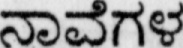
ನಾವೆಗಳ
